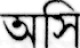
অসি
